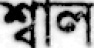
শ্বাল
